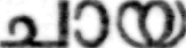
ചായ
